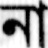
না
